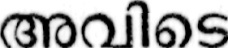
അവിടെ
